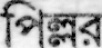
পিল্লর
